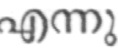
എന്നു
